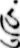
હું
